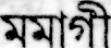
মমাগী
